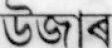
উজাৰ
